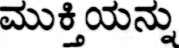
ಮುಕ್ತಿಯನ್ನು
